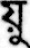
য়ু
